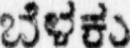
ಬೆಳಕು
